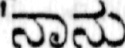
‘ನಾನು
